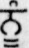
ਨੂੰ
